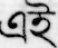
এই
